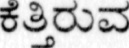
ಕೆತ್ತಿರುವ
